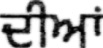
ਦੀਆਂ
